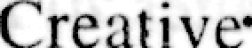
Creative
